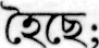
হৈছে;
